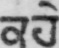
ਕਹੇ
